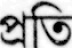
প্রতি
